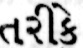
તરીકે
